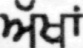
ਅੱਖਾਂ
